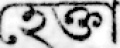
হেক্তা
